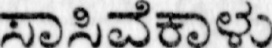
ಸಾಸಿವೆಕಾಳು
